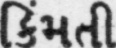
કિંમતી
